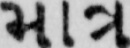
માત્ર
